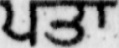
ਪਤਾ
